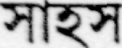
সাহস
